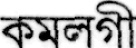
কমলগী
